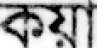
কয়া
